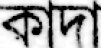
কাদা
